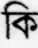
কি
